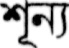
শূন্য
